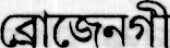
ব্রোজেনগী
